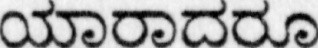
ಯಾರಾದರೂ
